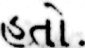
હતો.
